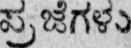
ಪ್ರಜೆಗಳು
